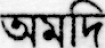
অমদি
